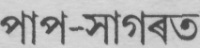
পাপ-সাগৰত
